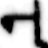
ન
